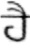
ਹੈ
